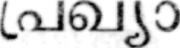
പ്രഖ്യാ
